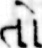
તો
